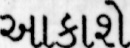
આકાશે
